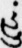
હું
